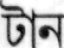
টান
